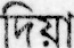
দিয়া
